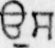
ਉਸ
